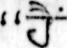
''ਹੈਂ
